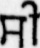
ਸੀ
